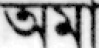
অমা
